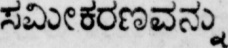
ಸಮೀಕರಣವನ್ನು
